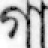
গা
